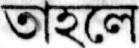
তাহলে
